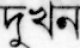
দুখন
